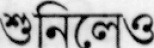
শুনিলেও
